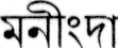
মনীংদা
